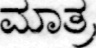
ಮಾತ್ರ
